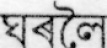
ঘৰলৈ
